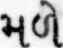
મળે
